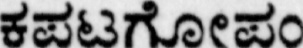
ಕಪಟಗೋಪಂ
